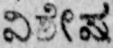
ವಿಶೇಷ
